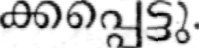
ക്കപ്പെട്ടു.
